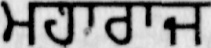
ਮਹਾਰਾਜ
